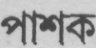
পাশক
